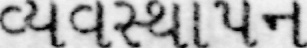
વ્યવસ્થાપન
